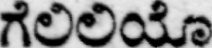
ಗೆಲಿಲಿಯೊ
